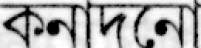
কনাদনো
